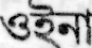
ওইনা
